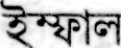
ইম্ফাল
